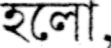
হলো,
